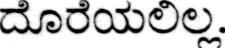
ದೊರೆಯಲಿಲ್ಲ.
